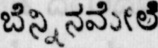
ಬೆನ್ನಿನಮೇಲೆ
